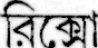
রিক্সো
